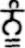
ਨੂੰ
